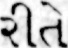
રીતે
